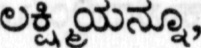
ಲಕ್ಷ್ಮಿಯನ್ನೂ,
